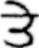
ਤੇ
